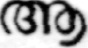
ആ
